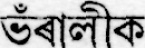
ভঁৰালীক
